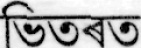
ভিতৰত
